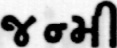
જન્મી
